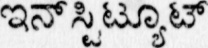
ಇನ್‌ಸ್ಟಿಟ್ಯೂಟ್
